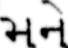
મને
